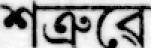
শত্রুৱে
